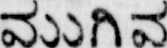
ಮುಗಿವ
